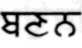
ਬਣਨ
